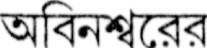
অবিনশ্বরের
